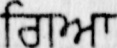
ਗਿਆ
